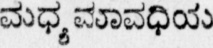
ಮಧ್ಯಮಾವಧಿಯ
